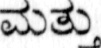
ಮತ್ತು
